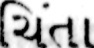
ચિંતા
